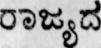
ರಾಜ್ಯದ
